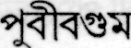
পুবীবগুম
